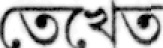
তেখেত
